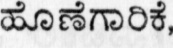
ಹೊಣೆಗಾರಿಕೆ,
